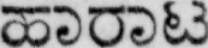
ಹಾರಾಟ
